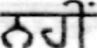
ਨਹੀਂ
